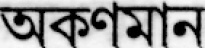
অকণমান
